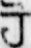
ਹੋ
